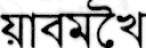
য়াবমখৈ
